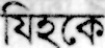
যিহকে
